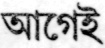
আগেই
